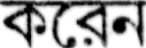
করেন
